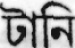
টানি
